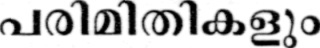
പരിമിതികളും
